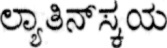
ಲ್ಯಾತಿನ್ಸ್ಕಯ
